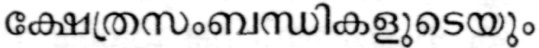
ക്ഷേത്രസംബന്ധികളുടെയും
